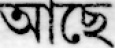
আছে
